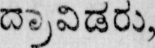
ದ್ರಾವಿಡರು,
